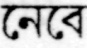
নেবে
